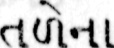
તળેના
